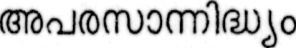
അപരസാന്നിദ്ധ്യം
